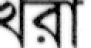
খরা
